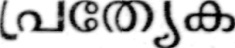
പ്രത്യേക
